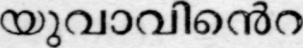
യുവാവിന്റെ
